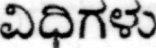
ವಿಧಿಗಳು
